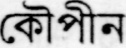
কৌপীন
